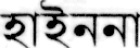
হাইননা
